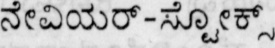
ನೇವಿಯರ್-ಸ್ಟೋಕ್ಸ್
